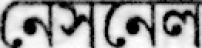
নেসনেল
